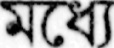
মধ্যে
